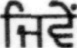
ਜਿਵੇਂ
